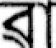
ৱা
